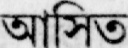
আসিত
